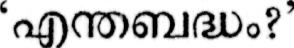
'എന്തബദ്ധം?'
